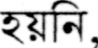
হয়নি,
